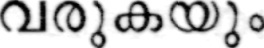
വരുകയും
